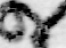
જ
